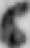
'મને
